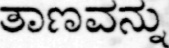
ತಾಣವನ್ನು
